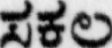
ಸಕಲ
